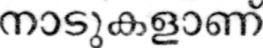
നാടുകളാണ്
